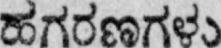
ಹಗರಣಗಳು
